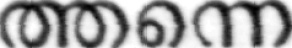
ത്തന്നെ
